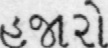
હજારો
